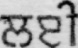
ਲਈ
